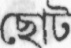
ছোট
